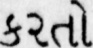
કરતો
